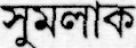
সুমলাক
